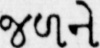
જળને
